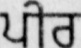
ਪੀਰ
